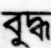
বুদ্ধ
